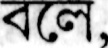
বলে,
